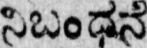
ನಿಬಂಧನೆ
